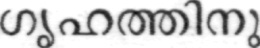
ഗൃഹത്തിനു
